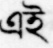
এই
